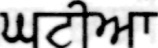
ਘਟੀਆ
